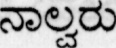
ನಾಲ್ವರು
